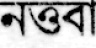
নত্তবা
